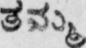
ತಮ್ಮ
